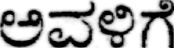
ಅವಳಿಗೆ
